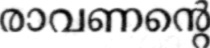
രാവണന്റെ
